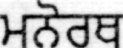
ਮਨੋਰਥ
